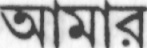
আমার
